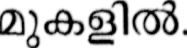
മുകളില്‍.
